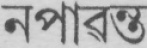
নপাৱন্ত
